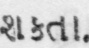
શકતા.
